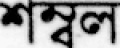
শম্বল
